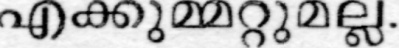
എക്കുമ്മറ്റുമല്ല.
